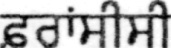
ਫ਼ਰਾਂਸੀਸੀ
